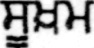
ਸੂਖ਼ਮ
